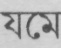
যমে
